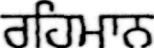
ਰਹਿਮਾਨ
